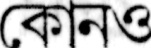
কোনও
